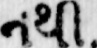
નથી.
